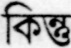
কিন্তু
